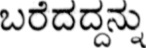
ಬರೆದದ್ದನ್ನು
